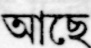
আছে
